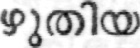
ഴുതിയ
